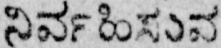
ನಿರ್ವಹಿಸುವ
